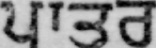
ਪਾਤਰ
